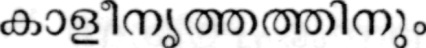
കാളീനൃത്തത്തിനും
